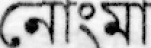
নোংমা
